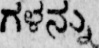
ಗಳನ್ನು
